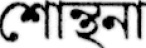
শোন্থনা
